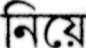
নিয়ে
